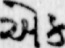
એક
